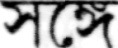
সঙ্গে
